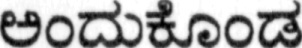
ಅಂದುಕೊಂಡ
